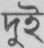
দুই
